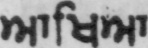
ਆਖਿਆ
